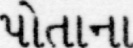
પોતાના
